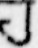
ਹ
